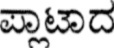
ಪ್ಲಾಟಾದ
